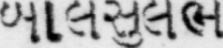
બાલસુલભ
